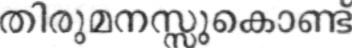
തിരുമനസ്സുകൊണ്ട്
